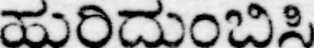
ಹುರಿದುಂಬಿಸಿ
